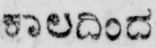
ಕಾಲದಿಂದ
